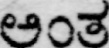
ಅ೦ತ
